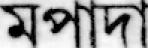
মপাদা
